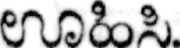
ಊಹಿಸಿ.
